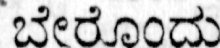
ಬೇರೊಂದು
